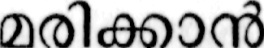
മരിക്കാന്‍
